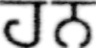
ਹਨ
